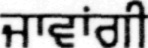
ਜਾਵਾਂਗੀ
